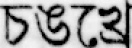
চঙখ্রে
